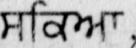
ਸਕਿਆ,
